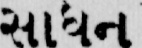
સાધન
